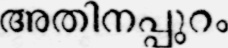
അതിനപ്പുറം
